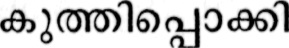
കുത്തിപ്പൊക്കി
